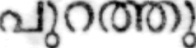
പുറത്തു
